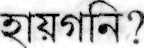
হায়গনি?
